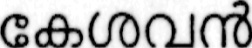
കേശവന്‍
